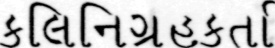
કલિનિગ્રહકર્તા
